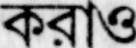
করাও
